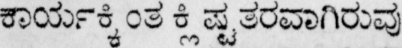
ಕಾರ್ಯಕ್ಕಿಂತ ಕ್ಲಿಷ್ಟತರವಾಗಿರುವು
